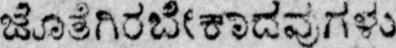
ಜೊತೆಗಿರಬೇಕಾದವುಗಳು
